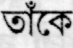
তাঁকে
